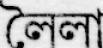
লৈলা
